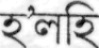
হ'লহি
